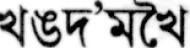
খঙদ’মখৈ
